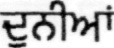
ਦੁਨੀਆਂ
